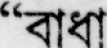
"বাধা
